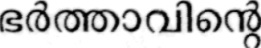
ഭര്‍ത്താവിന്റെ
